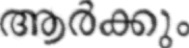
ആര്‍ക്കും
